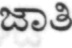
ಜಾತಿ
